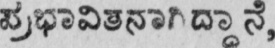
ಪ್ರಭಾವಿತನಾಗಿದ್ದಾನೆ,
